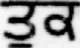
ਤੁਕ
